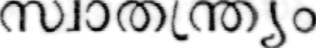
സ്വാതന്ത്ര്യം
